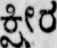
ಕ್ಷೀರ
